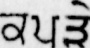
ਕਪੜੇ
